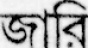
জারি
